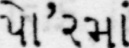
પો'રમાં
